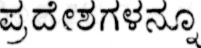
ಪ್ರದೇಶಗಳನ್ನೂ
